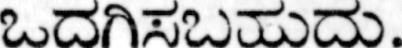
ಒದಗಿಸಬಹುದು.
